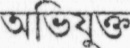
অভিযুক্ত
